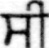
ਸੀ
